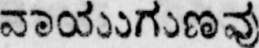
ವಾಯುಗುಣವು
